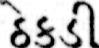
ઠેકડી
